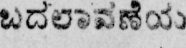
ಬದಲಾವಣೆಯ
